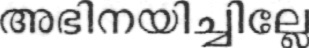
അഭിനയിച്ചില്ലേ
